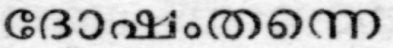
ദോഷംതന്നെ
